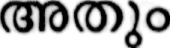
അതും
